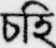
চহি
